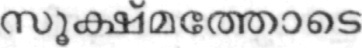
സൂക്ഷ്മത്തോടെ
